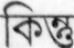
কিন্তু
